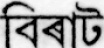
বিৰাট
